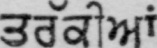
ਤਰੱਕੀਆਂ
